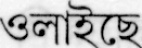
ওলাইছে
